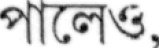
পালেও,
